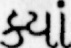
ક્યાં
